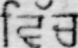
ਵਿੱਚ
